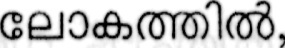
ലോകത്തില്‍,
